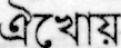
ঐখোয়
